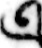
এ
